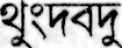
থুংদবদু
